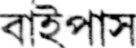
বাইপাস
